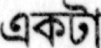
একটা
